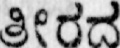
ತೀರದ
